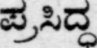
ಪ್ರಸಿದ್ಧ
